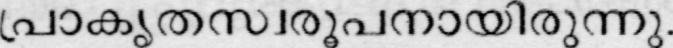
പ്രാകൃതസ്വരൂപനായിരുന്നു.
